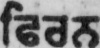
ਫਿਰਨ
